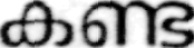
കണ്ട
